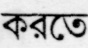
করতে
